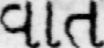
વાત
